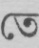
তে
